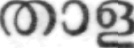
താള
